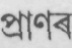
প্রাণৰ
